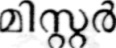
മിസ്റ്റര്‍
